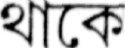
থাকে
